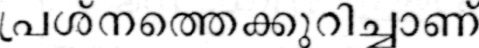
പ്രശ്നത്തെക്കുറിച്ചാണ്
